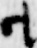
ન
